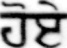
ਹੋਏ
